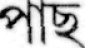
পাছ
